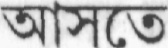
আসতে
